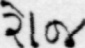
રોજ
